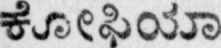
ಕೋಫಿಯಾ
